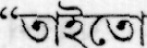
"তাইতো
